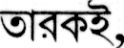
তারকই,
